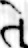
તે
